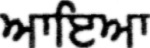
ਆਇਆ
